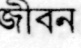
জীবন
